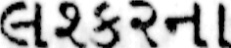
લશ્કરના
